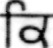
ਕਿ
